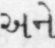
અને
